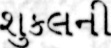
શુક્લની
